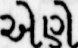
એણે
